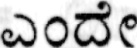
ಎಂದೇ
